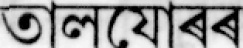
তালযোৰৰ
